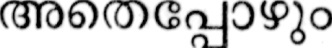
അതെപ്പോഴും
